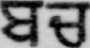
ਬਚ
